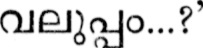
വലുപ്പം...?'
